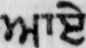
ਆਏ
